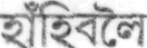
হাঁহিবলৈ
